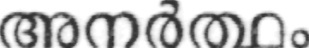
അനര്‍ത്ഥം
